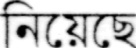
নিয়েছে
